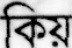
কিয়
